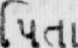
પિતા
